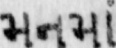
મનમાં
